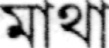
মাথা
